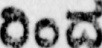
ರಿಂದ
